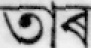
তাৰ
